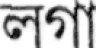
লগা
